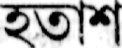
হতাশ
